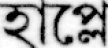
হাপ্লে
